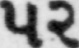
પર
